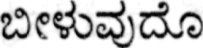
ಬೀಳುವುದೊ
